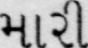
મારી
